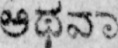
ಅಥವಾ
